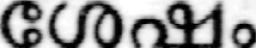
ശേഷം
